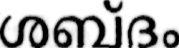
ശബ്ദം
